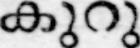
കുറു
